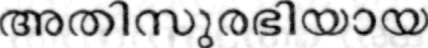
അതിസുരഭിയായ
